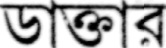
ডাক্তার
